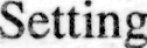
Setting
